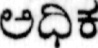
ಅಧಿಕ
